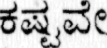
ಕಷ್ಟವೇ
